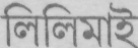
লিলিমাই
